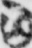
છે
